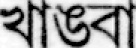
খাঙবা
